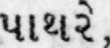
પાથરે,
